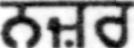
ਨਜ਼ਰ
